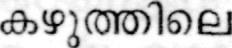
കഴുത്തിലെ
